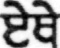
ਏਥੇ
